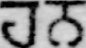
ਹਨ
